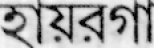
হায়রগা
